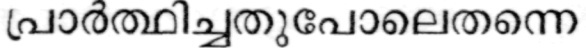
പ്രാര്‍ത്ഥിച്ചതുപോലെതന്നെ
